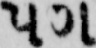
પગ
